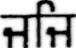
ਜਜਿ
